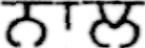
ਨਾਲ
